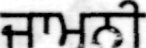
ਜਾਮਨੀ
